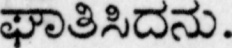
ಘಾತಿಸಿದನು.
